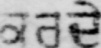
ਕਰਦੇ
